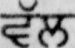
ਵੱਲ
